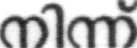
നിന്ന്
